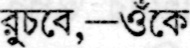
রুচবে,—ওঁকে
